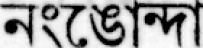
নংঙোন্দা
